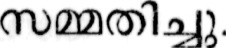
സമ്മതിച്ചു.
